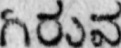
ಗಿರುವ
